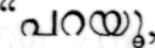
"പറയൂ,
